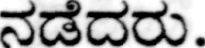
ನಡೆದರು.
